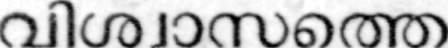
വിശ്വാസത്തെ
